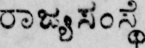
ರಾಜ್ಯಸಂಸ್ಥೆ
